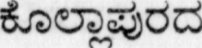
ಕೊಲ್ಲಾಪುರದ
